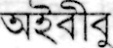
অইবীবু
